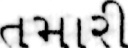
તમારી
